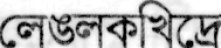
লেঙলকখিদ্রে
